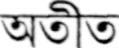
অতীত
